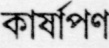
কার্ষাপণ
